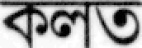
কলত
